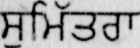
ਸੁਮਿੱਤਰਾ
